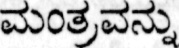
ಮಂತ್ರವನ್ನು
